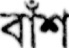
বাঁশ
